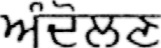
ਅੰਦੋਲਣ
